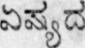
ಏಷ್ಯದ
